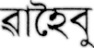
ৱাহৈবু
